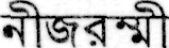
নীজরম্মী
